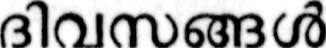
ദിവസങ്ങള്‍
